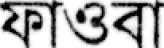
ফাওবা
